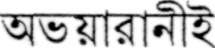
অভয়ারানীই
